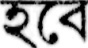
হবে
